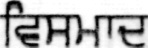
ਵਿਸਮਾਦ
